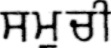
ਸਮੁਚੀ
